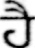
ਹੈ
